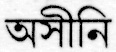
অসীনি
